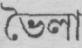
ভৈলা
